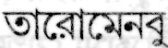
তারোমেনবু
